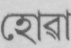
হোৱা
